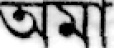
অমা
